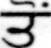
ਤੋਂ
